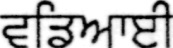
ਵਡਿਆਈ
